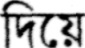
দিয়ে
